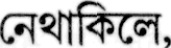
নেথাকিলে,
